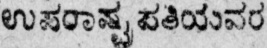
ಉಪರಾಷ್ಟ್ರಪತಿಯವರ
